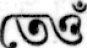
তেওঁ
